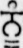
ਨੂੰ
